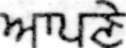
ਆਪਣੇ
